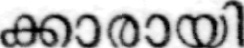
ക്കാരായി
